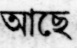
আছে
